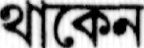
থাকেন
